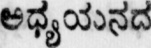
ಅಧ್ಯಯನದ
